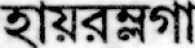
হায়রম্লগা
